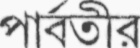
পার্বতীর
